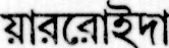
য়াররোইদা
